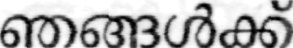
ഞങ്ങള്‍ക്ക്
